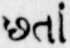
છતાં
